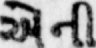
એની
